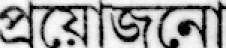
প্রয়োজনো
